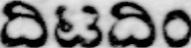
ದಿಟದಿಂ
